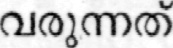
വരുന്നത്
